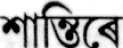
শান্তিৰে
